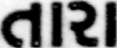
તારા
